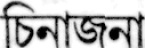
চিনাজনা
